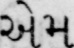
એમ
